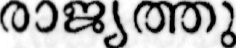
രാജ്യത്തു
